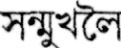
সন্মুখলৈ
